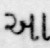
આ
